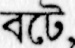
বটে,
